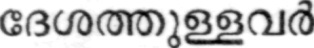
ദേശത്തുള്ളവര്‍
